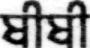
ਬੀਬੀ
